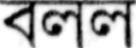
বলল
